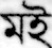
মই
